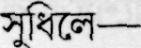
সুধিলে-
